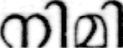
നിമി
